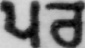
ਪਰ
